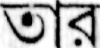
তার
